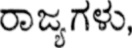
ರಾಜ್ಯಗಳು,
